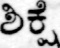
ಶಿಕ್ಷೆ
